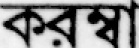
করম্বা
